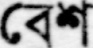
বেশ
